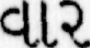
વાર
